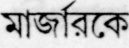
মার্জারকে
